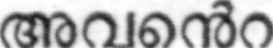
അവന്റെ
